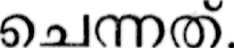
ചെന്നത്.
